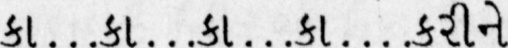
કા...કા...કા...કા...કરીને
